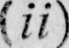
(ii)
